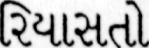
રિયાસતો
